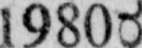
1980ರ
